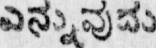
ಎನ್ನುವುದು
